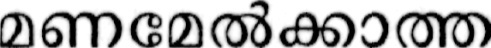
മണമേല്‍ക്കാത്ത
